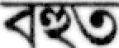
বহুত
